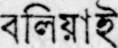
বলিয়াই
